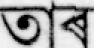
তাৰ
